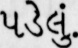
પડેલું.
